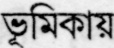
ভূমিকায়
